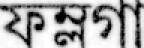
ফম্লগা
